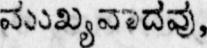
ಮುಖ್ಯವಾದವು,
